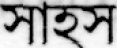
সাহস
